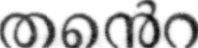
തന്റെ
